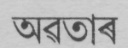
অৱতাৰ
